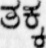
ತಕ್ಕ
